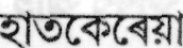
হাতকেৰেয়া
